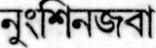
নুংশিনজবা
